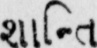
શાન્તિ
